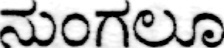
ನುಂಗಲೂ
